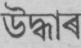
উদ্ধাৰ
